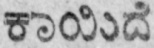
ಕಾಯಿದೆ
